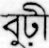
বুঢ়ী
